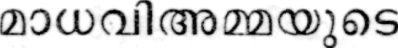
മാധവിഅമ്മയുടെ
